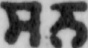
ਸਨ
